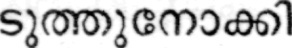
ടുത്തുനോക്കി
